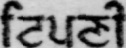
ਟਿਪਣੀ
